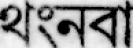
থংনবা
